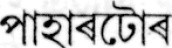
পাহাৰটোৰ
